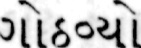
ગોઠવ્યો
